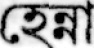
হেন্না
